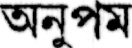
অনুপম
